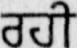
ਰਹੀ
